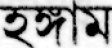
হঙ্গাম
